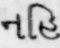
નહિ
